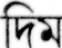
দিম
